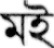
মই
